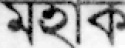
মহাক
